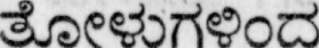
ತೋಳುಗಳಿಂದ
